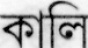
কালি
